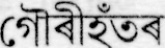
গৌৰীহঁতৰ
